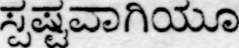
ಸ್ಪಷ್ಟವಾಗಿಯೂ
